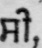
ਸੀ,
